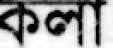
কলা
